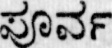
ಪೂರ್ವ
